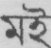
মই
